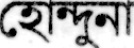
হোন্দুনা
